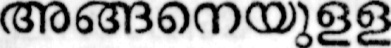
അങ്ങനെയുള്ള
